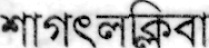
শাগৎলক্লিবা
